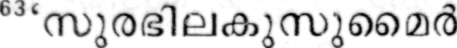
63'സുരഭിലകുസുമൈര്‍
